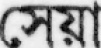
সেয়া
